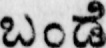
ಬಂಡೆ
